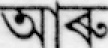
আৰু
